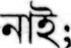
নাই;
